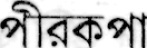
পীরকপা
